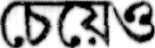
চেয়েও
